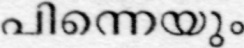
പിന്നെയും
